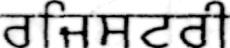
ਰਜਿਸਟਰੀ
